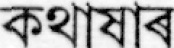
কথাষাৰ
